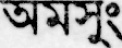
অমসুং
